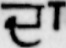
ਦਾ
